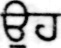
ਉਹ
